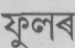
ফুলৰ
